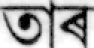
তাৰ
